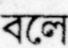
বলে
